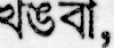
খঙবা,
